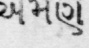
એમણે
